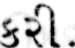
કરી.
